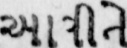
આવીને
